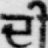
ਦੀ
